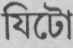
যিটো
